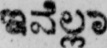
ಇವೆಲ್ಲಾ
